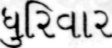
ધુરિવાર
